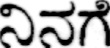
ನಿನಗೆ
